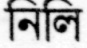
নিলি
